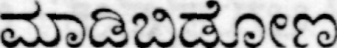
ಮಾಡಿಬಿಡೋಣ
